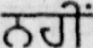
ਨਹੀਂ
